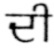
ਦੀ
